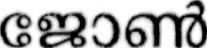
ജോണ്‍
